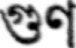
গুণ
